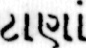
ટાણાં
